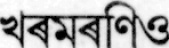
খৰমৰণিও
